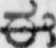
ಈ
